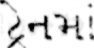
ટ્રેનમાં
